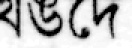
খঙদে
